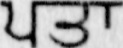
ਪਤਾ
